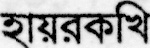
হায়রকখি
